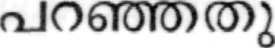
പറഞ്ഞതു
